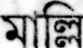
মাল্লি
